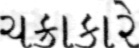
ચક્રાકારે
